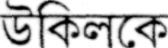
উকিলকে
